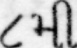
૮મી
